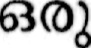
ഒരു
